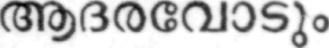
ആദരവോടും
